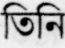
তিনি
